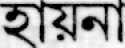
হায়না
